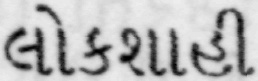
લોકશાહી
